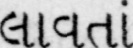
લાવતાં
